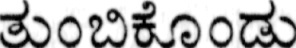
ತುಂಬಿಕೊಂಡು
